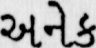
અનેક
